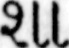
શા
